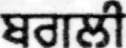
ਬਗਲੀ
